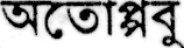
অতোপ্পবু
